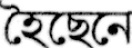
হৈছেনে
